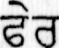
ਫੇਰ
